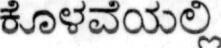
ಕೊಳವೆಯಲ್ಲಿ
